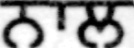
ਨਾਲ
